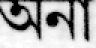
অনা
